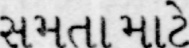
સમતામાટે
